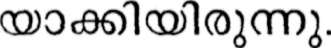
യാക്കിയിരുന്നു.
